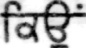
ਕਿਉਂ
